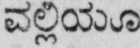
ವಲ್ಲಿಯೂ
